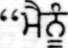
''ਮੈਨੂੰ
